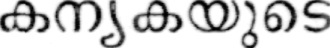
കന്യകയുടെ
